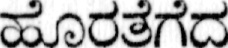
ಹೊರತೆಗೆದ
